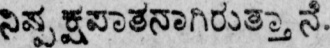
ನಿಷ್ಪಕ್ಷಪಾತನಾಗಿರುತ್ತಾನೆ.
